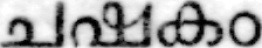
ചഷകം
